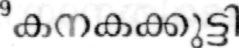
9കനകക്കുട്ടി
